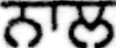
ਨਾਲ
